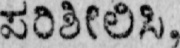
ಪರಿಶೀಲಿಸಿ,
